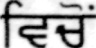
ਵਿਚੋਂ
